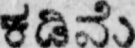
ಕಡಿಮೆ
